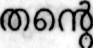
തന്റെ
